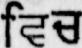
ਵਿਚ
